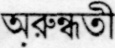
অরুন্ধতী
